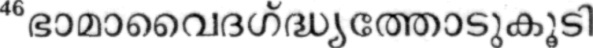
46ഭാമാവൈദഗ്ദ്ധ്യത്തോടുകൂടി
